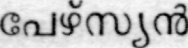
പേഴ്സ്യന്‍
